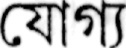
যোগ্য
